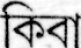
কিবা
